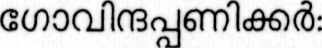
ഗോവിന്ദപ്പണിക്കര്‍:
